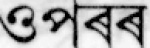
ওপৰৰ
